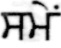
ਸਮੇਂ
